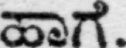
ಹಾಗೆ.
